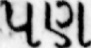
પણ
